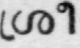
ശ്രീ
